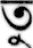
তু
